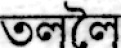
তললৈ
